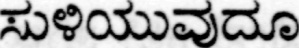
ಸುಳಿಯುವುದೂ
